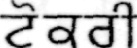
ਟੋਕਰੀ
